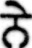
ਨੇ
